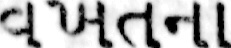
વખતના
